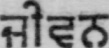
ਜੀਵਨ
